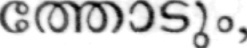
ത്തോടും,
